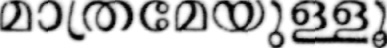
മാത്രമേയുള്ളൂ
